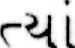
ત્યાં
